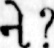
ને?
